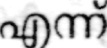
എന്ന്
